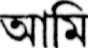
আমি
